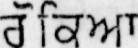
ਰੋਕਿਆ
